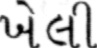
ખેલી
